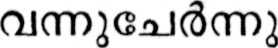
വന്നുചേര്‍ന്നു
